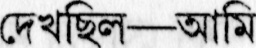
দেখছিল–আমি
